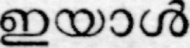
ഇയാള്‍
